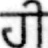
ਹੀ
